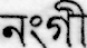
নংগী
